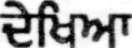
ਦੇਖਿਆ
